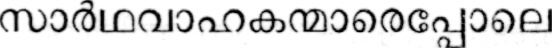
സാര്‍ഥവാഹകന്മാരെപ്പോലെ
